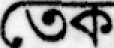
তেক
